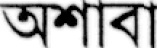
অশাবা
